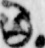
છે.
